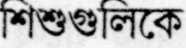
শিশুগুলিকে
